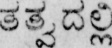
ತತ್ವದಲ್ಲಿ
